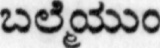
ಬಲ್ಮೆಯುಂ
